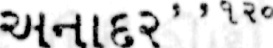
અનાદર"૧૨૦
